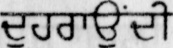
ਦੁਹਰਾਉਂਦੀ
